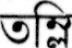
তম্লি
